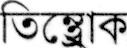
তিন্থ্রোক
